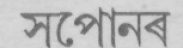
সপোনৰ
